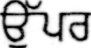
ਉੱਪਰ
